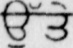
ਉੱਤੇ
